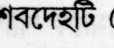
শবদেহটি
